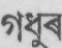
গধুৰ
